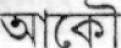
আকৌ
